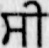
ਸੀ
